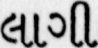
લાગી
